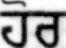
ਹੋਰ
